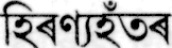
হিৰণ্যহঁতৰ
